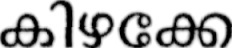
കിഴക്കേ
